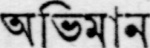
অভিমান
